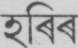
হৰিৰ
